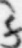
કે
